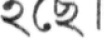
হছে
